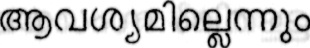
ആവശ്യമില്ലെന്നും
